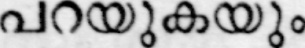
പറയുകയും
